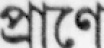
প্রাণে
